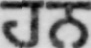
ਹਨ
